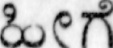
ಹೀಗೆ
